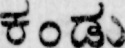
ಕಂಡು
